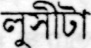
লুসীটা
